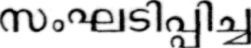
സംഘടിപ്പിച്ച
